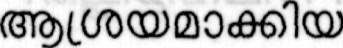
ആശ്രയമാക്കിയ
